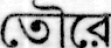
তৌরে
